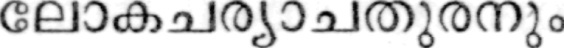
ലോകചര്യാചതുരനും
